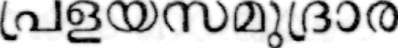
പ്രളയസമുദ്രാര
